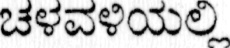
ಚಳವಳಿಯಲ್ಲಿ
